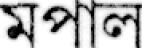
মপাল
